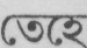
তেহে
